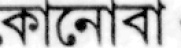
কোনোবা
